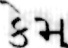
કેમ
